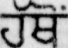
ਹੱਥੋਂ
